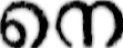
നെ
